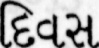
દિવસ
